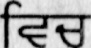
ਵਿਚ
